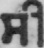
ਸੀ
